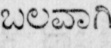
ಬಲವಾಗಿ
